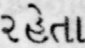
રહેતા
